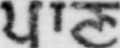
ਪਾਣ
